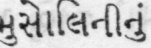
મુસોલિનીનું
